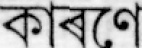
কাৰণে
